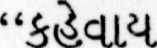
"કહેવાય
